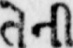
તેની
